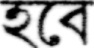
হবে
